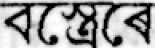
বস্ত্রেৰে
